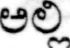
ಅಲ್ಲಿ
